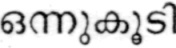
ഒന്നുകൂടി
